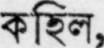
কহিল,
